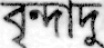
বৃন্দাদু
